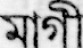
মাগী
